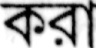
করা
